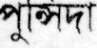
পুন্সিদা
